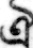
ঐ
